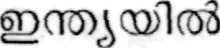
ഇന്ത്യയില്‍
